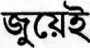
জুয়েই
